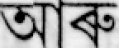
আৰু
